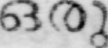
ഒരു
